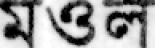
মওল
